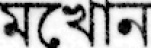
মখোন
